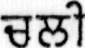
ਚਲੀ
